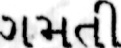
ગમતી
